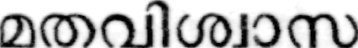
മതവിശ്വാസ
